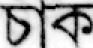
চাক
